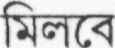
মিলবে
